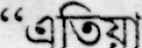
"এতিয়া
